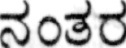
ನಂತರ
